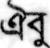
ঐবু
